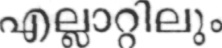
എല്ലാറ്റിലും
